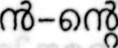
ന്‍-ന്റെ
